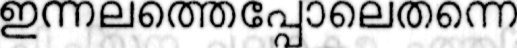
ഇന്നലത്തെപ്പോലെതന്നെ
